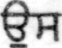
ਉਸ
